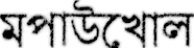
মপাউখোল
